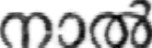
നാല്‍
